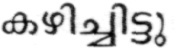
കഴിച്ചിട്ടു
